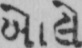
બોલે
